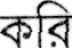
করি
